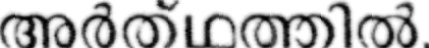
അര്‍ത്ഥത്തില്‍.
